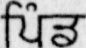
ਪਿੰਡ
